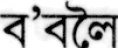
ব'বলৈ
